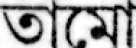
তামো
